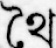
থৈ
